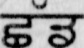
ਛੱਡ
